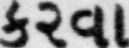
કરવા
